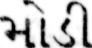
મોડી
